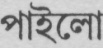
পাইলো
